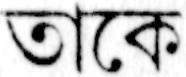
তাকে
